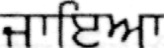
ਜਾਇਆ
